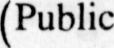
(Public
